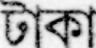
টাকা
